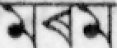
মৰম
